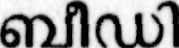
ബീഡി
